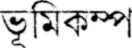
ভূমিকম্প
